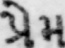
પ્રેમ
